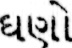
ઘણો
